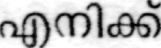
എനിക്ക്
